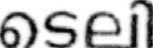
ടെലി
